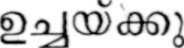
ഉച്ചയ്ക്കു
